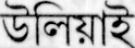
উলিয়াই
